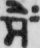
ਸੈਂ
